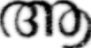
ആ
